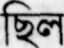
ছিল
